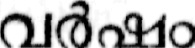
വര്‍ഷം
